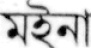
মইনা
